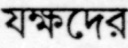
যক্ষদের
